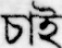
চাই
